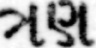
ત્રણ
